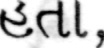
હતા,
